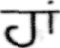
ਹਾਂ
